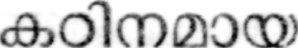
കഠിനമായ
